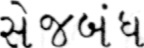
સેજબંધ
